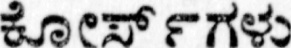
ಕೋರ್ಸ್‌ಗಳು
